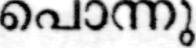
പൊന്നു
